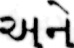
અને
